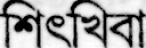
শিৎখিবা
